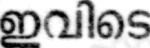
ഇവിടെ
